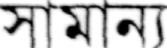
সামান্য
